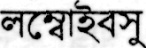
লম্বোইবসু
